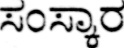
ಸಂಸ್ಕಾರ
